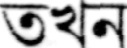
তখন
